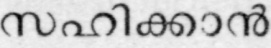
സഹിക്കാന്‍
